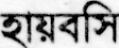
হায়বসি
